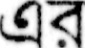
এর
